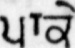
ਪਾਕੇ
